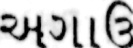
અગાઉ
